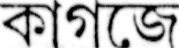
কাগজে
